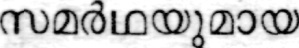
സമര്‍ഥയുമായ
